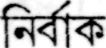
নির্বাক
